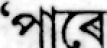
'পাৰে
